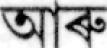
আৰু
